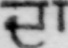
ਦਾ
